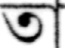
তা
